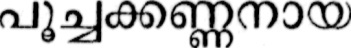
പൂച്ചക്കണ്ണനായ
